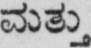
ಮತ್ತು
